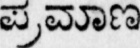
ಪ್ರಮಾಣ
